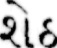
શેઠ
